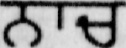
ਨਾਚ
